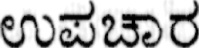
ಉಪಚಾರ
